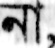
না,
